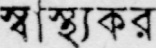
স্বাস্থ্যকর
